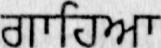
ਗਾਹਿਆ
